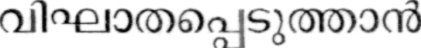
വിഘാതപ്പെടുത്താന്‍
